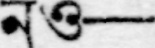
নও—
